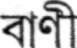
বাণী
